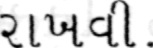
રાખવી.
